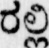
ರಲ್ಲಿ
